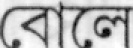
বোলে
